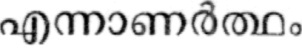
എന്നാണര്‍ത്ഥം
